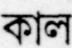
কাল
